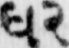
ધર
